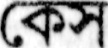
কেস
